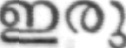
ഇരു
